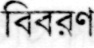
বিবরণ
